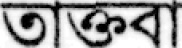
তাক্তবা
